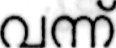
വന്ന്
